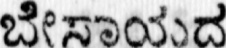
ಬೇಸಾಯದ
